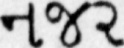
નજર
